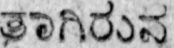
ತಾಗಿರುವ
